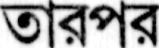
তারপর
